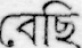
বেছি
